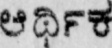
ಆರ್ಥಿಕ
